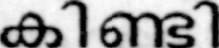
കിണ്ടി
